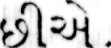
છીએ.
